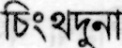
চিংথদুনা
